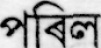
পৰিল
